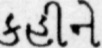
કહીને
